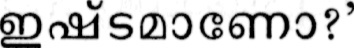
ഇഷ്ടമാണോ?’
